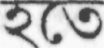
হতে
